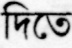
দিতে
